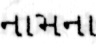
નામના
